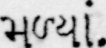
મળ્યાં.
